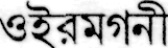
ওইরমগনী
